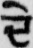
ਦੇ
